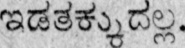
ಇಡತಕ್ಕುದಲ್ಲ.
